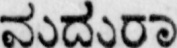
ಮದುರಾ
